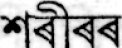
শৰীৰৰ
